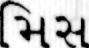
મિસ
